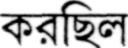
করছিল
